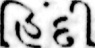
હિંદી
